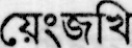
য়েংজখি
